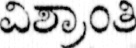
ವಿಶ್ರಾಂತಿ
